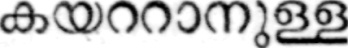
കയററാനുള്ള
